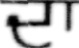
ਦਾ
